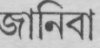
জানিবা
